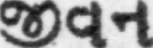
જીવન
